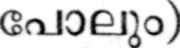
പോലും)
